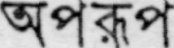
অপরূপ
